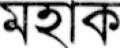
মহাক
